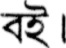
বই।
